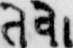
તેવો
